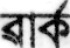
ৱার্ক
